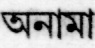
অনামা
